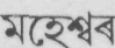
মহেশ্বৰ
